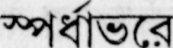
স্পর্ধাভরে
